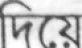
দিয়ে
